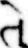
તે
